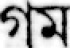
গম
